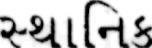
સ્થાનિક
